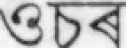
ওচৰ
